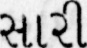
સારી
